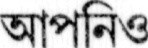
আপনিও
